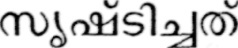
സൃഷ്ടിച്ചത്
